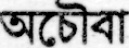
অচৌবা
